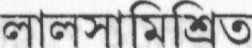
লালসামিশ্রিত
